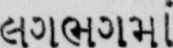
લગભગમાં
